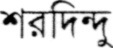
শরদিন্দু
